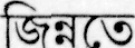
জিন্নতে
